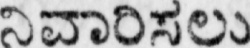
ನಿವಾರಿಸಲು
